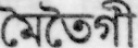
মৈতৈগী
